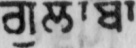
ਗੁਲਾਬਾ
